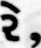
રે,
